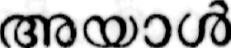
അയാള്‍
